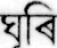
ঘূৰি
